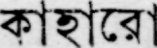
কাহারো
